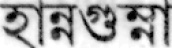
হান্নগুম্না
